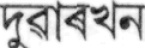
দুৱাৰখন
